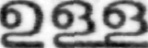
ഉള്ള
